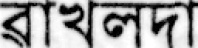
ৱাখলদা
